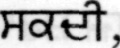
ਸਕਦੀ,
